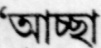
‘আচ্ছা
